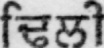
ਢਿਲੀ
